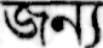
জন্য
